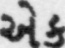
એક
